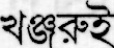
খঞ্জরুই
